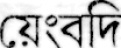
য়েংবদি
